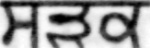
ਸੜਕ
